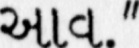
આવ."
